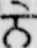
ਨੇ
